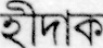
হীদাক
